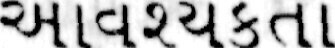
આવશ્યકતા
